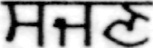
ਸਜਣ
